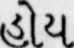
હોય
